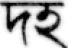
দহ
